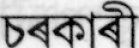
চৰকাৰী
